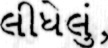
લીધેલું,
